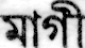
মাগী
